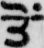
ਤੋਂ
